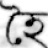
হৈ
